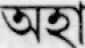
অহা
